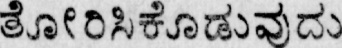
ತೋರಿಸಿಕೊಡುವುದು
